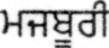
ਮਜਬੂਰੀ
